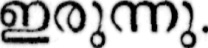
ഇരുന്നു.
